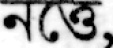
নত্তে,
